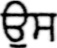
ਉਸ
